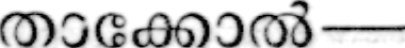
താക്കോല്‍-
